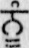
ਨੂੰ
